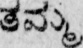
ತಮ್ಮ
